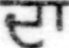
ਦਾ
